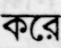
করে
